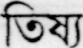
তিষ্য
